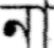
না
